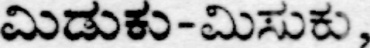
ಮಿಡುಕು-ಮಿಸುಕು,
